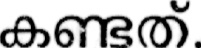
കണ്ടത്.
